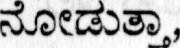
ನೋಡುತ್ತಾ,
